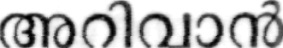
അറിവാന്‍
